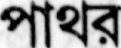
পাথর
